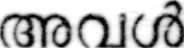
അവള്‍
